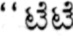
"ಟೆಟೆ
